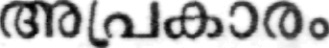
അപ്രകാരം
